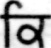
ਕਿ
